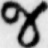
જ
